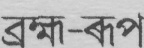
ব্ৰহ্ম-ৰূপ
